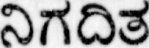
ನಿಗದಿತ
